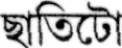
ছাতিটো
